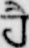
ਹੈ
